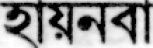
হায়নবা
